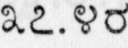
೩೭.೪ರ
